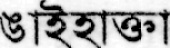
ঙাইহাক্তা
